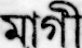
মাগী
